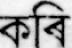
কৰি
